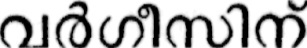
വര്‍ഗീസിന്
